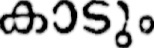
കാടും
